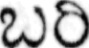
ಬರಿ
